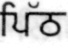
ਪਿੱਠ
